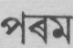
পৰম
